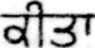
ਕੀਤਾ
